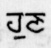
ਹੁਣ
